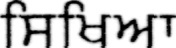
ਸਿਖਿਆ
